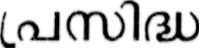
പ്രസിദ്ധ
